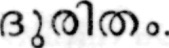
ദുരിതം.
